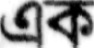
এক
